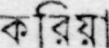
করিয়া
